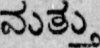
ಮತ್ತು
